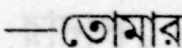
–তোমার
